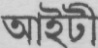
আইটী
